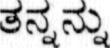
ತನ್ನನ್ನು
